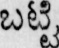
ಬಟ್ಟೆ
